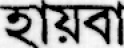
হায়বা
